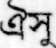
ঐসু
